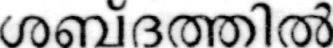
ശബ്ദത്തില്‍
